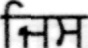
ਜਿਸ
